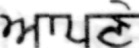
ਆਪਣੇ
